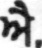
ਐ,
